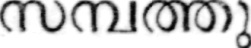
സമ്പത്തു
